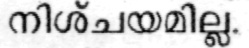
നിശ്ചയമില്ല.
